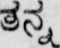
ತನ್ನ
